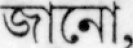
জানো,
